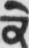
ਕੇ
